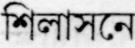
শিলাসনে
